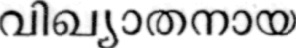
വിഖ്യാതനായ
